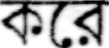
করে
